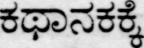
ಕಥಾನಕಕ್ಕೆ
